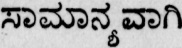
ಸಾಮಾನ್ಯವಾಗಿ
